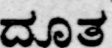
ದೂತ
